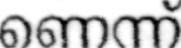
ണെന്ന്
